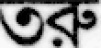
তরু
